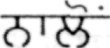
ਨਾਲੋਂ
